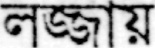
লজ্জায়
